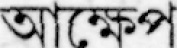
আক্ষেপ
